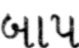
બાપ
